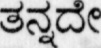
ತನ್ನದೇ
